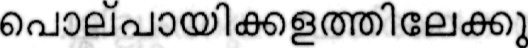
പൊല്പായിക്കളത്തിലേക്കു
